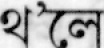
থ'লে
